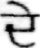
ਦੇ
